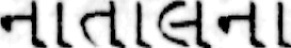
નાતાલના
